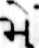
મેં
